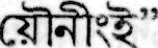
য়ৌনীংই”
